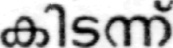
കിടന്ന്
